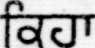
ਕਿਹਾ
